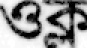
ওক্ল
